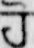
ਹੋ
